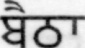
ਬੈਠਾ
